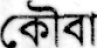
কৌবা
